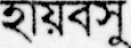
হায়বসু
